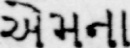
એમના
